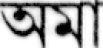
অম
